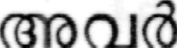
അവര്‍
